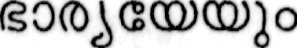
ഭാര്യയേയും
